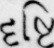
દષ્ટિ
